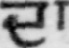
ਦਾ
